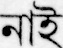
নাই
